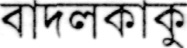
বাদলকাকু
